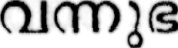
വന്നുഭ
